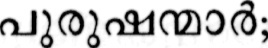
പുരുഷന്മാര്‍;
